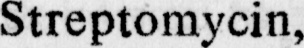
Streptomycin,
